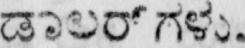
ಡಾಲರ್‌ಗಳು.
